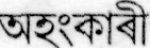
অহংকাৰী
